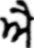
ਐ
